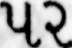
પર
